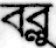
বব্লু
